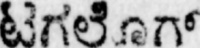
ಟಗಲೊಗ್
